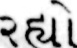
રહ્યો
